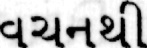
વચનથી
